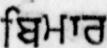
ਬਿਮਾਰ
